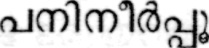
പനിനീര്‍പ്പൂ
